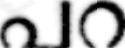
പറ
